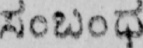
ಸಂಬಂಧ
